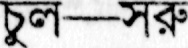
চুল–সরু
